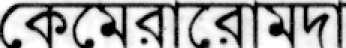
কেমেরারোমদা
